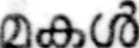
മകള്‍
